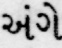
અંગે
